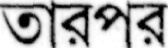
তারপর
